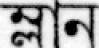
ম্লান
